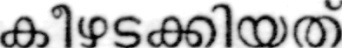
കീഴടക്കിയത്
